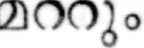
മററും
